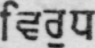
ਵਿਰੁਧ
